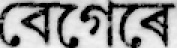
বেগেৰে
